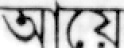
আয়ে
